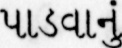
પાડવાનું
